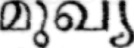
മുഖ്യ
